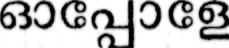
ഓപ്പോളേ
